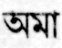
অমা
